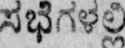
ಸಭೆಗಳಲ್ಲಿ
